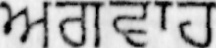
ਅਗਵਾਹ
